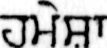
ਹਮੇਸ਼ਾ
